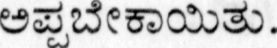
ಅಪ್ಪಬೇಕಾಯಿತು.
